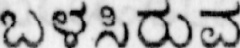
ಬಳಸಿರುವ
